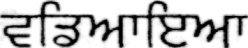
ਵਡਿਆਇਆ
